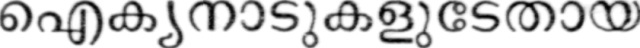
ഐക്യനാടുകളുടേതായ
